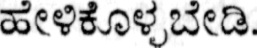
ಹೇಳಿಕೊಳ್ಳಬೇಡಿ.
